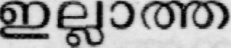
ഇല്ലാത്ത
